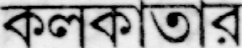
কলকাতার
